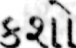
કશો
